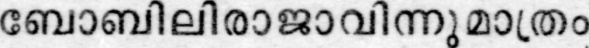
ബോബിലിരാജാവിന്നുമാത്രം
